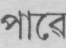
পাৱে
